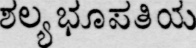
ಶಲ್ಯಭೂಪತಿಯ
